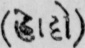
(હોદ્દો)
